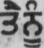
ਤੈਨੂੰ
